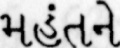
મહંતને
